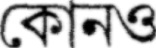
কোনও
